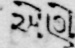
એણે
